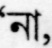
‘না,
